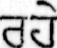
ਰਹੇ
